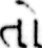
તો
